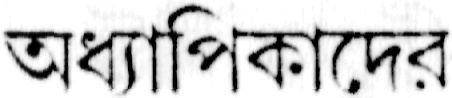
অধ্যাপিকাদের
